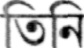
তিনি
